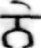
ਨੇ
